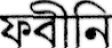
ফবীনি
